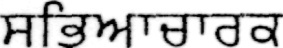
ਸਭਿਆਚਾਰਕ
